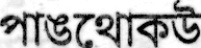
পাঙথোকউ
